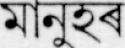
মানুহৰ
